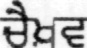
ਚੈਖ਼ਵ
